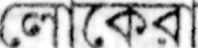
লোকেরা
